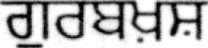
ਗੁਰਬਖ਼ਸ਼
